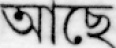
আছে
